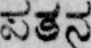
ಪತನ
